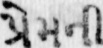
પ્રેમની
